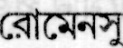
রোমেন
